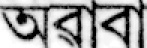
অৱাবা
